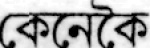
কেনেকৈ
